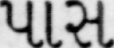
પાસ
